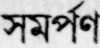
সমর্পণ
